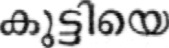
കുട്ടിയെ
